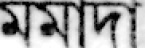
মমাদা
